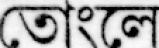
তোংলে
